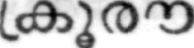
ക്രൂരൌ
